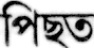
পিছত
